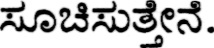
ಸೂಚಿಸುತ್ತೇನೆ.
